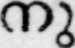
നു
